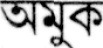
অমুক
